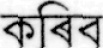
কৰিব
